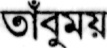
তাঁবুময়
